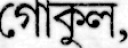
গোকুল,
